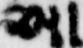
આ
